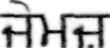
ਜੇਮਜ਼
